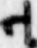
ન
